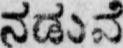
ನಡುವೆ
